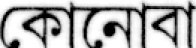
কোনোবা
